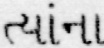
ત્યાંના
